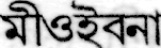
মীওইবনা
